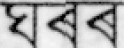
ঘৰৰ
